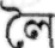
লৈ
